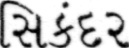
સિકંદર
